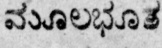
ಮೂಲಭೂತ
